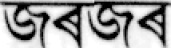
জৰজৰ
